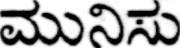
ಮುನಿಸು
